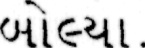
બોલ્યા.
